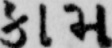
કામ
